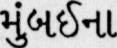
મુંબઈના
